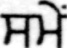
ਸਮੇਂ
